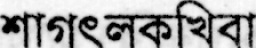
শাগৎলকখিবা
